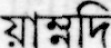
য়াম্নদি
